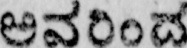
ಅವರಿಂದ
